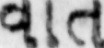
વાત
